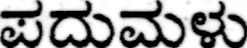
ಪದುಮಳು
